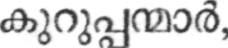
കുറുപ്പന്മാര്‍,
